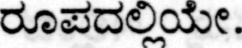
ರೂಪದಲ್ಲಿಯೇ.
